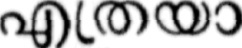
എത്രയാ
